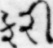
ફરી
